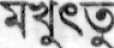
মখুৎতু
